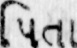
પિતા
